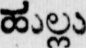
ಹುಲ್ಲು
